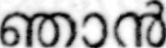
ഞാന്‍
